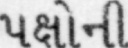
પક્ષોની
